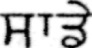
ਸਾਡੇ
